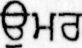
ਉਮਰ
